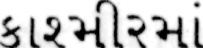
કાશ્મીરમાં
